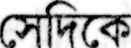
সেদিকে
